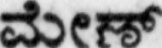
ಮೇಣ್
